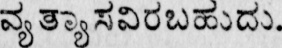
ವ್ಯತ್ಯಾಸವಿರಬಹುದು.
